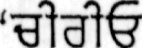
'ਚੀਰੀਓ
